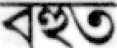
বহুত
